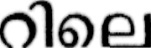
റിലെ
